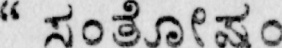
“ಸಂತೋಷಂ
